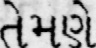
તેમણે
